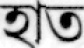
হাত
